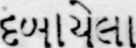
દબાયેલા
